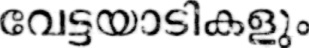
വേട്ടയാടികളും
